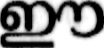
ഈ
